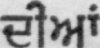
ਦੀਆਂ
